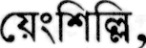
য়েংশিল্লি,
